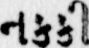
નક્કી
